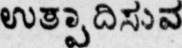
ಉತ್ಪಾದಿಸುವ
